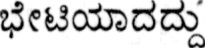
ಭೇಟಿಯಾದದ್ದು
